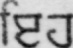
ਇਹ
